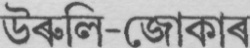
উৰুলি-জোকাৰ
